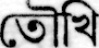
তৌখি
